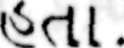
હતા.
